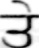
ਤੇ
